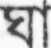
ঘা
